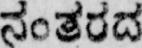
ನಂತರದ
